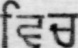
ਵਿਚ
